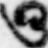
ও
